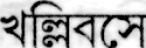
খল্লিবসে
